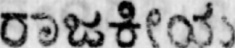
ರಾಜಕೀಯ
